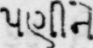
પણીને
